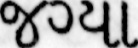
જગ્યા
